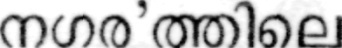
നഗര’ത്തിലെ
